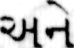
અને
